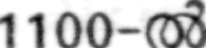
1100-ല്‍
